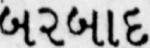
બરબાદ
